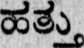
ಹತ್ತು
